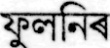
ফুলনিৰ
